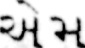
એમ
